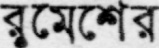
রমেশের
